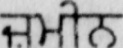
ਜ਼ਮੀਨ
